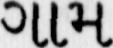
ગામ
